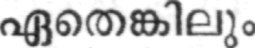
ഏതെങ്കിലും
